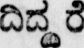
ದಿದ್ದರೆ
